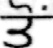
ਤੋਂ
